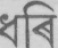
ধৰি
